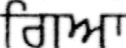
ਗਿਆ
